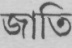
জাতি
